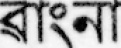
ৱাংনা
